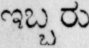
ಇಬ್ಬರು
